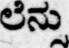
ಲೆನ್ಸು
